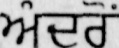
ਅੰਦਰੋਂ
